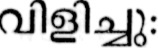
വിളിച്ചു:
